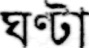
ঘণ্টা
